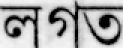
লগত
